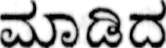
ಮಾಡಿದ
